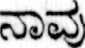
ನಾವು
